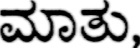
ಮಾತು,
